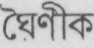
ঘৈণীক
